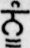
ਨੂੰ
